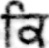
ਕਿ
